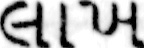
લાખ
